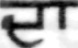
ਦਾ
